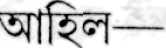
আহিল-
